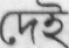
দেই
